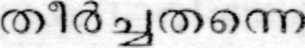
തീര്‍ച്ചതന്നെ
